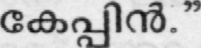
കേപ്പിന്‍."
